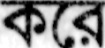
করে
